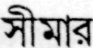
সীমার
